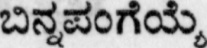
ಬಿನ್ನಪಂಗೆಯ್ಯೆ
